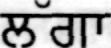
ਲੱਗਾ
